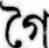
গৈ
